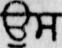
ਉਸ
